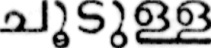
ചൂടുള്ള
